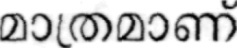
മാത്രമാണ്
